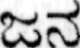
ಜನ
